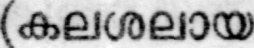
(കലശലായ
